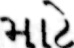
માટે
